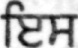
ਇਸ
